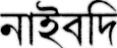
নাইবদি
